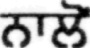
ਨਾਲੋਂ
